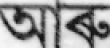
আৰু
